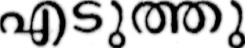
എടുത്തു
